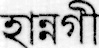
হান্নগী
